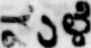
ಮಳೆ
